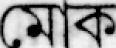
মোক
